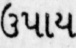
ઉપાય
